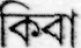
কিবা
